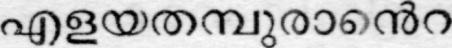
എളയതമ്പുരാന്റെ
